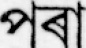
পৰা
